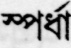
স্পর্ধা
